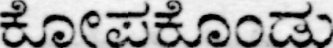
ಕೋಪಗೊಂಡು
